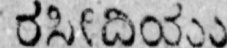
ರಸೀದಿಯು
